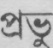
প্ৰভু
